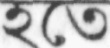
হতে
